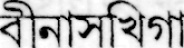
বীনাসখিগা
